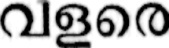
വളരെ
